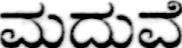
ಮದುವೆ
